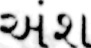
અંશ
